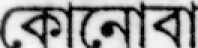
কোনোবা
